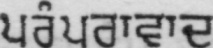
ਪਰੰਪਰਾਵਾਦ
